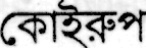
কোইরুপ
